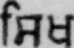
ਸਿਖ
